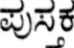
ಪುಸ್ತಕ
